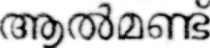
ആല്‍മണ്ട്
